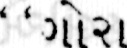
"ગોરા
